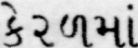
કેરળમાં
